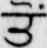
ਤੋਂ
